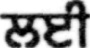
ਲਈ
